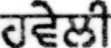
ਹਵੇਲੀ
